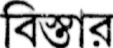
বিস্তার
